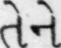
તેને
